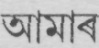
আমাৰ
